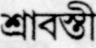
শ্রাবস্তী
